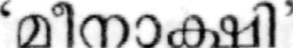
'മീനാക്ഷി'
